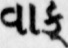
વાક્
